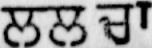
ਲਲਚਾ
